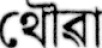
থৌৱা
